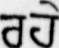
ਰਹੇ
